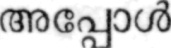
അപ്പോള്‍
